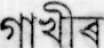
গাখীৰ
